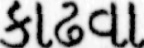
કાઢવા
